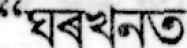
"ঘৰখনত
